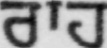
ਰਾਹ
